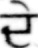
ਦੇ
